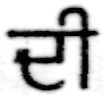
ਦੀ
